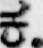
ಕ.
